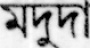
মদুদা
